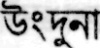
উংদুনা
